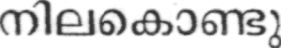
നിലകൊണ്ടു
